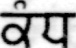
ਕੰਧ
